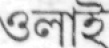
ওলাই
